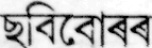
ছবিবোৰৰ
